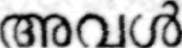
അവള്‍
